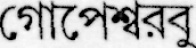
গোপেশ্বরবু
